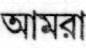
আমরা
